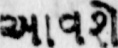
આવશે
